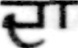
ਦਾ
